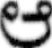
ಆ
